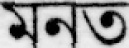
মনত
